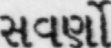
સવર્ણો
